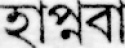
হাপ্নবা
